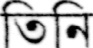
তিনি
